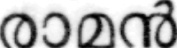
രാമന്‍
